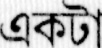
একটা
